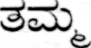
ತಮ್ಮ
